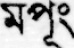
মপূং
